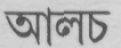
আলচ
